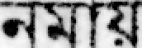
নমায়
